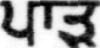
ਪਾੜ
